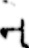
ને
